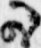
જે
